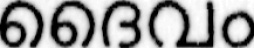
ദൈവം
